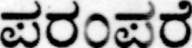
ಪರಂಪರೆ
